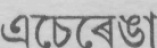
এচেৰেঙা
